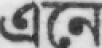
এনে
